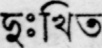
দুঃখিত
